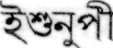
ইশুনুপী
